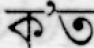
ক'ত
